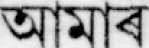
আমাৰ
